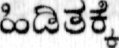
ಹಿಡಿತಕ್ಕೆ
